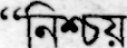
"নিশ্চয়
